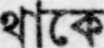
থাকে
